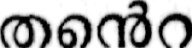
തന്റെ
